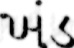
ખંડ
